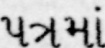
પત્રમાં
